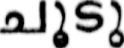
ചൂടു
